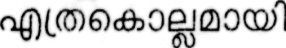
എത്രകൊല്ലമായി
